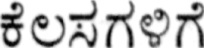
ಕೆಲಸಗಳಿಗೆ
